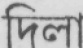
দিলা
